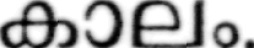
കാലം.
